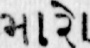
મારો
